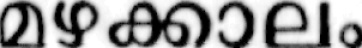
മഴക്കാലം
